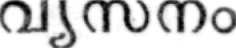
വ്യസനം
